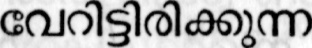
വേറിട്ടിരിക്കുന്ന
